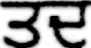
ਤਦ
